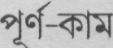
পূৰ্ণ-কাম
